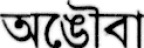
অঙৌবা
